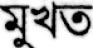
মুখত
